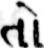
તો
